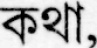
কথা,
